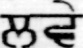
ਲਵੇ
